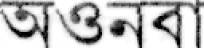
অওনবা
